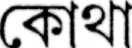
কোথা
